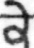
ਕੇ
